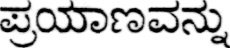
ಪ್ರಯಾಣವನ್ನು
